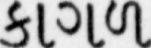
કાગળ
